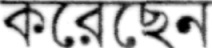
করেছেন
